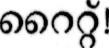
റൈറ്റ്!
